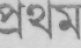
প্ৰথম
